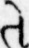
તે
